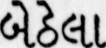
બેઠેલા
